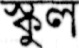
স্কুল
